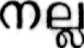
നല്ല
